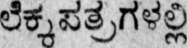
ಲೆಕ್ಕಪತ್ರಗಳಲ್ಲಿ
